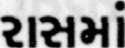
રાસમાં
